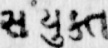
સંયુક્ત
